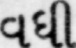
વધી
